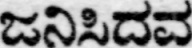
ಜನಿಸಿದವ
